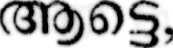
ആട്ടെ,
